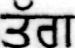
ਤੱਗ
